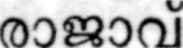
രാജാവ്
